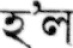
হ'ল
